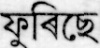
ফুৰিছে
